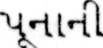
પૂનાની
